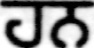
ਹਨ
